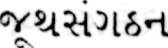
જૂથસંગઠન
